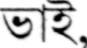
ভাই,
